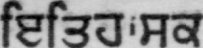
ਇਤਿਹਾਸਕ
